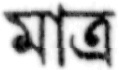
মাত্র
